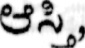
ಆಸ್ತಿ,
